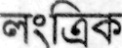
লংত্রিক
